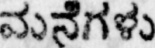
ಮನೆಗಳು
